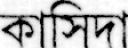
কাসিদা
